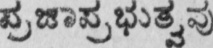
ಪ್ರಜಾಪ್ರಭುತ್ವವು
